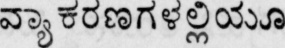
ವ್ಯಾಕರಣಗಳಲ್ಲಿಯೂ
